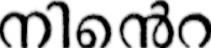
നിന്റെ
